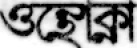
ওন্থোক্না
